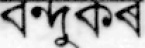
বন্দুকৰ
